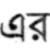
এর
